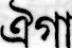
ঐগা
